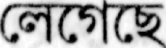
লেগেছে
